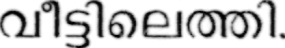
വീട്ടിലെത്തി.
